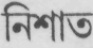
নিশাত
